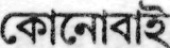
কোনোবাই
